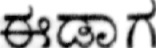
ಈಡಾಗ
